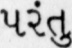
પરંતુ
